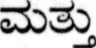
ಮತ್ತು
